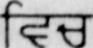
ਵਿਚ
